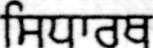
ਸਿਧਾਰਥ
